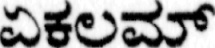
ಏಕಲಮ್
